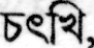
চৎখি,
